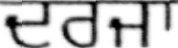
ਦਰਜਾ
